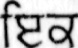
ਇਕ
